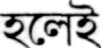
হলেই
